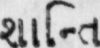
શાન્તિ
